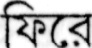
ফিরে
